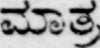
ಮಾತ್ರ
